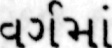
વર્ગમાં
